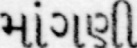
માંગણી
